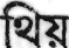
থিয়
